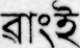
ৱাংই
